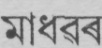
মাধৱৰ
